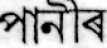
পানীৰ
